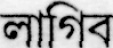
লাগিব
